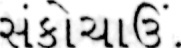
સંકોચાઉં.
